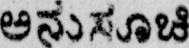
ಅನುಸೂಚಿ
